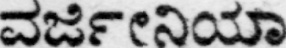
ವರ್ಜೀನಿಯಾ
